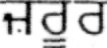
ਜ਼ਰੂਰ
